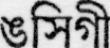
ঙসিগী
